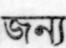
জন্য
